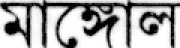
মাঙ্গোল
